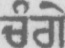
ਚੰਗੇ
